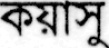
কয়াসু
